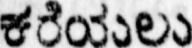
ಕರೆಯಲು
